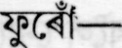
ফুৰোঁ-
